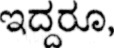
ಇದ್ದರೂ,
